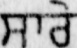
ਸਾਰੇ
